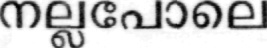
നല്ലപോലെ
